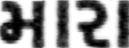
મારા
